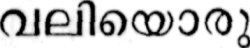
വലിയൊരു
